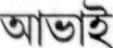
আভাই
